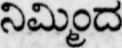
ನಿಮ್ಮಿಂದ
